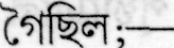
গৈছিল;-
